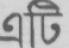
এটি
